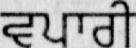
ਵਪਾਰੀ
